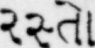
રસ્તો
